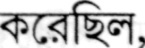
করেছিল,
